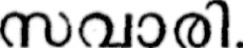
സവാരി.
